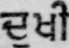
ਦੁਖੀ
